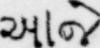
આજે
